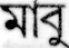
মাবু
